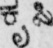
ಕೃಷಿ
